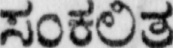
ಸಂಕಲಿತ
